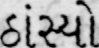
ઠાંસ્યો
